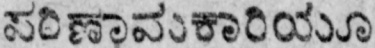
ಪರಿಣಾಮಕಾರಿಯೂ
